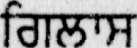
ਗਿਲਾਸ
